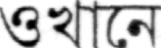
ওখানে
